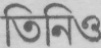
তিনিও
